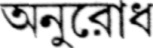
অনুরোধ
